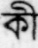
কী
